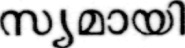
സ്യമായി
